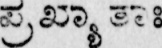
ಪ್ರಖ್ಯಾತಾಃ
